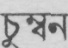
চুম্বন
